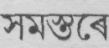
সমস্তৰে
